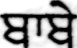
ਬਾਬੇ
